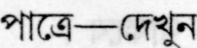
পাত্রে–দেখুন
